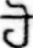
ਹੋ
